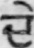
ਦੇ
